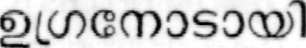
ഉഗ്രനോടായി
